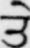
ਤੇ
